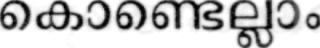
കൊണ്ടെല്ലാം
